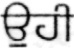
ਉਹੀ
